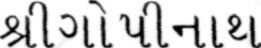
શ્રીગોપીનાથ
